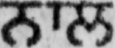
ਨਾਲ
